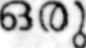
ഒരു
